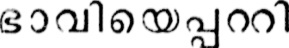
ഭാവിയെപ്പററി
